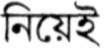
নিয়েই
